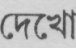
দেখো
